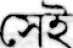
সেই
